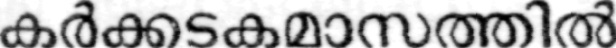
കര്‍ക്കടകമാസത്തില്‍
